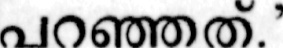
പറഞ്ഞത്.’
